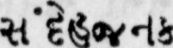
સંદેહજનક
